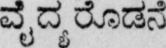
ವೈದ್ಯರೊಡನೆ
